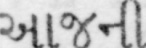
આજની
